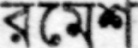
রমেশ
